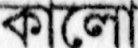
কালো
